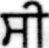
ਸੀ
